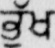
ਭੁੱਖ
